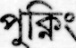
পুক্নিং
